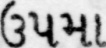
ઉપમા
